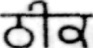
ਠੀਕ
